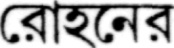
রোহনের
